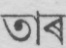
তাৰ
